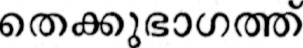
തെക്കുഭാഗത്ത്
